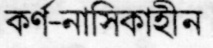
কর্ণ-নাসিকাহীন
